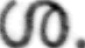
ശ.
